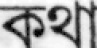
কথা
